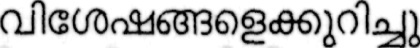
വിശേഷങ്ങളെക്കുറിച്ചു
